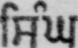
ਸਿੰਘ
